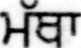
ਮੱਥਾ
